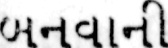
બનવાની
